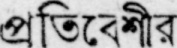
প্রতিবেশীর
